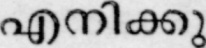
എനിക്കു
